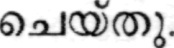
ചെയ്തു.
